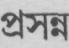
প্ৰসন্ন
